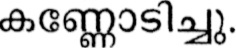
കണ്ണോടിച്ചു.
